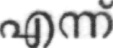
എന്ന്
